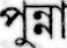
পুন্না
